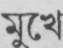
মুখে
